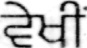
ਵੇਖੀ
